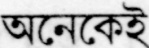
অনেকেই
